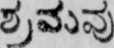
ಶ್ರಮವು
